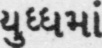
યુધ્ધમાં
